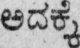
ಅದಕ್ಕೆ
